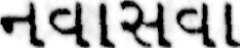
નવાસવા
